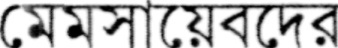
মেমসায়েবদের
